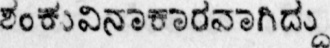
ಶಂಕುವಿನಾಕಾರವಾಗಿದ್ದು
